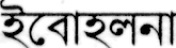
ইবোহলনা
